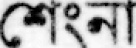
শেংনা
